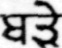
ਬੜੇ
